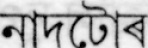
নাদটোৰ
